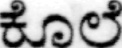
ಕೊಲೆ
